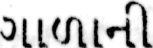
ગાળાની
